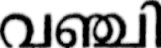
വഞ്ചി
